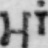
ਮਾਂ
